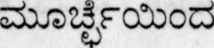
ಮೂರ್ಚ್ಛೆಯಿಂದ
